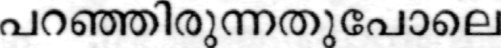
പറഞ്ഞിരുന്നതുപോലെ
